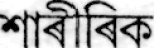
শাৰীৰিক
